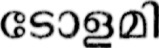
ടോളമി
